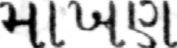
માખણ
